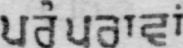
ਪਰੰਪਰਾਵਾਂ
